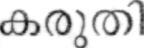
കരുതി
